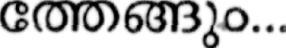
ത്തേങ്ങും…
